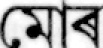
মোৰ
